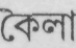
কৈলা
